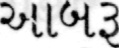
આબરૂ
